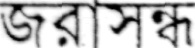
জরাসন্ধ
